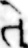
તે
